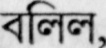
বলিল,
